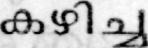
കഴിച്ച
